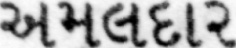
અમલદાર
